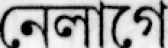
নেলাগে
